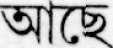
আছে
